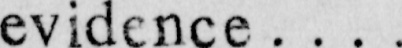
evidence....
